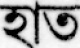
হাত
